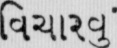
વિચારવું
